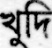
খুদি
